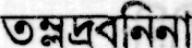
তম্লদ্রবনিনা
